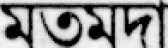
মতমদা
